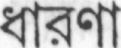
ধারণা
